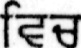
ਵਿਚ
